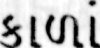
કાળાં
